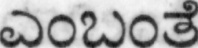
ಎಂಬಂತೆ
